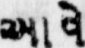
આવે
